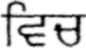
ਵਿਚ
